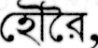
হৌরৈ,
